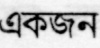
একজন
